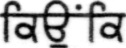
ਕਿਉਂਕਿ
